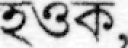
হওক,
